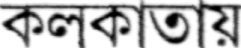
কলকাতায়
